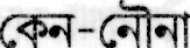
কেন-নৌনা
